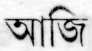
আজি
